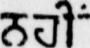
ਨਹੀਂ
